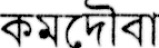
কমদৌবা
